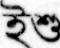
ইশু
